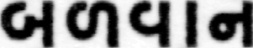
બળવાન
